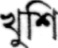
খুশি
